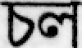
চল
